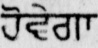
ਹੋਵੇਗਾ
